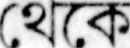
থেকে
